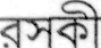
রসকী
